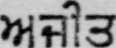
ਅਜੀਤ
